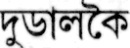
দুডালকৈ
